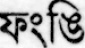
ফংঙি
